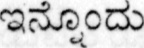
ಇನ್ನೊಂದು
